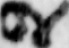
જ
